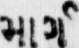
માર્ગ
